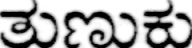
ತುಣುಕು
